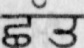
ਛੱਤ
